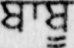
ਬਾਬੂ
